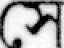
সে
